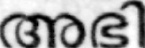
അഭി
